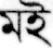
মই
